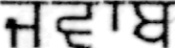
ਜਵਾਬ
